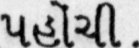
પહોંચી.
